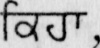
ਕਿਹਾ,
